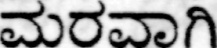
ಮರವಾಗಿ
